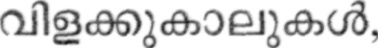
വിളക്കുകാലുകള്‍,
